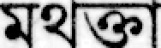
মথক্তা
